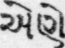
એણે
